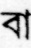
বা
